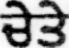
ਚੇਤੇ
